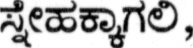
ಸ್ನೇಹಕ್ಕಾಗಲಿ,
